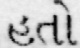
હતો
